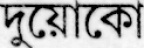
দুয়োকো
